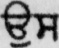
ਉਸ
